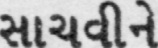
સાચવીને
